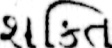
શક્તિ
